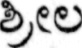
ಶ್ರೀಲ
